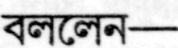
বললেন–
